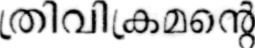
ത്രിവിക്രമന്റെ
